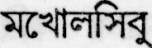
মখোলসিবু
